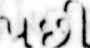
પછી
